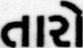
તારો
